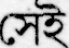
সেই
